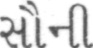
સૌની
